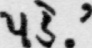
પડે.'
